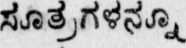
ಸೂತ್ರಗಳನ್ನೂ
